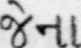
જેના
